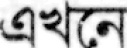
এখনে
